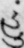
હું
